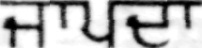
ਜਾਪਦਾ
